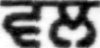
ਵਲ
